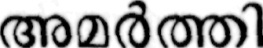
അമര്‍ത്തി
